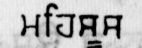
ਮਹਿਸੂਸ
